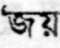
‘জয়
